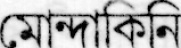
মোন্দাকিনি
